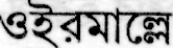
ওইরমাল্লে
